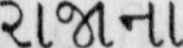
રાજાના
